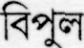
বিপুল
